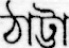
ঠাট্টা
